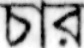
চার
